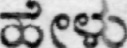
ಹೇಳು
